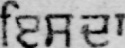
ਇਸਦਾ
